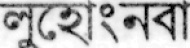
লুহোংনবা
